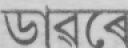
ডাৱৰে
